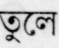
তুলে
